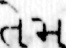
તેમ
